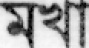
মখা
